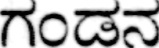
ಗಂಡನ
